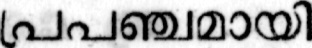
പ്രപഞ്ചമായി
